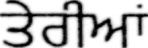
ਤੇਰੀਆਂ
